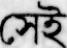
সেই
